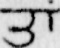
ਤਾਂ
